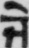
ਜੇ
